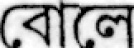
বোলে
